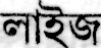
লাইজ
